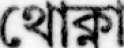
থোক্না
